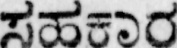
ಸಹಕಾರ
